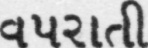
વપરાતી
